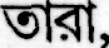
তারা,
